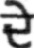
ਦੇ
